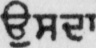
ਉਸਦਾ
